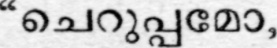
"ചെറുപ്പമോ,
